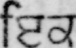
ਇਕ
